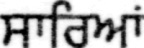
ਸਾਰਿਆਂ
